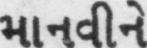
માનવીને
